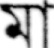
মা
